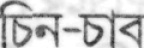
চিন-চাব
